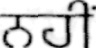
ਨਹੀਂ
